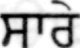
ਸਾਰੇ
